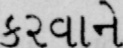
કરવાને
